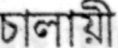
চালায়ী
